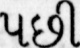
પછી
